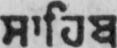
ਸਾਹਿਬ
